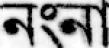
নংনা
